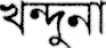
খন্দুনা
